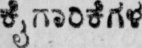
ಕೈಗಾರಿಕೆಗಳ
